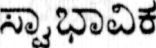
ಸ್ವಾಭಾವಿಕ
